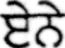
ਏਨੇ
